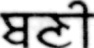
ਬਣੀ
